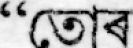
"তোৰ
